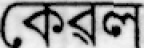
কেৱল
